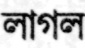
লাগল
